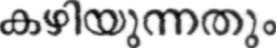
കഴിയുന്നതും
